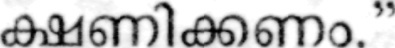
ക്ഷണിക്കണം.”
